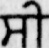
ਸੀ
